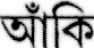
আঁকি
